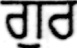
ਗੁਰ
